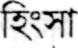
হিংসা
